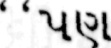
"પણ
